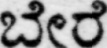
ಬೇರೆ
